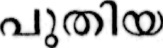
പുതിയ
